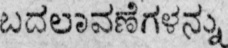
ಬದಲಾವಣೆಗಳನ್ನು
